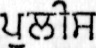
ਪੁਲੀਸ
